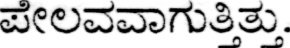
ಪೇಲವವಾಗುತ್ತಿತ್ತು.
